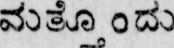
ಮತ್ತೊಂದು
